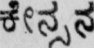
ಕೇನ್ಸನ
